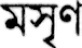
মসৃণ
